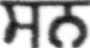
ਸਨ
